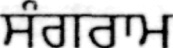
ਸੰਗਰਾਮ
